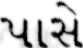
પાસે
